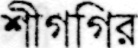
শীগগির
